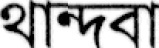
থান্দবা
